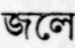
জলে
